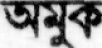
অমুক
